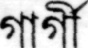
গার্গী
